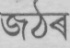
জঠৰ
